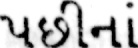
પછીનાં
